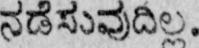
ನಡೆಸುವುದಿಲ್ಲ.
